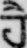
ਹੈ
